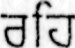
ਰਹਿ
